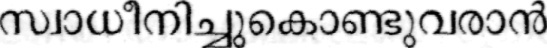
സ്വാധീനിച്ചുകൊണ്ടുവരാന്‍
